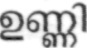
ഉണ്ണി
